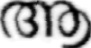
ആ
